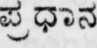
ಪ್ರಧಾನ
